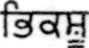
ਭਿਕਸ਼ੂ
